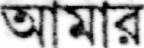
আমার
